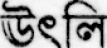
ঊৎলি
